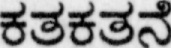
ಕತಕತನೆ
